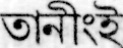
তানীংই
